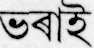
ভৰাই
